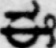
ಈ
